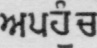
ਅਪਹੁੰਚ
